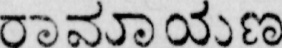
ರಾಮಾಯಣ
